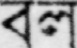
বল
